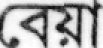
বেয়া
